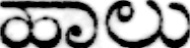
ಹಾಲು
